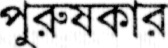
পুরুষকার
